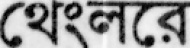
থেংলরে
